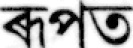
ৰূপত
